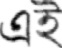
এই
